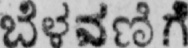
ಬೆಳವಣಿಗೆ
